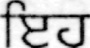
ਇਹ
